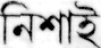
নিশাই
